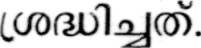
ശ്രദ്ധിച്ചത്.
